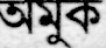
অমুক
